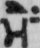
ਮੈਂ
